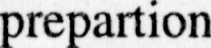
prepartion
